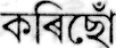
কৰিছোঁ
